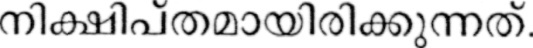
നിക്ഷിപ്തമായിരിക്കുന്നത്.
